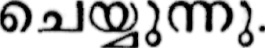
ചെയ്യുന്നു.
